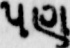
પણ
